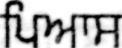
ਪਿਆਸ
